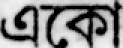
একো
